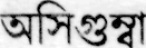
অসিগুম্বা
